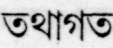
তথাগত
